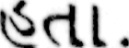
હતા.
